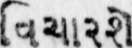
વિચારશે
